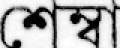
শেম্বা
